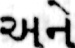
અને
